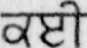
ਕਈ
